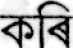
কৰি
